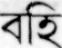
বহি
